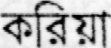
করিয়া
